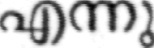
എന്നു
